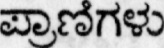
ಪ್ರಾಣಿಗಳು
